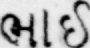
ભાઈ
